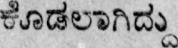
ಕೊಡಲಾಗಿದ್ದು
